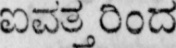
ಐವತ್ತರಿಂದ
